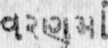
વરણમાં
